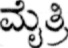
ಮೈತ್ರಿ
